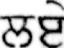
ਲਏ
